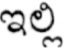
ಇಲ್ಲಿ
